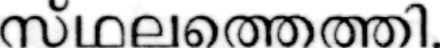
സ്ഥലത്തെത്തി.
